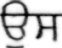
ਉਸ
